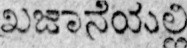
ಖಜಾನೆಯಲ್ಲಿ
